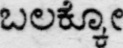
ಬಲಕ್ಕೋ
